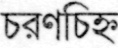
চরণচিহ্ন
